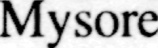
Mysore
